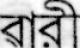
ৱারী
